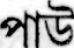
পাউ
